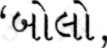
'બોલો,
